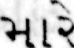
મારે
